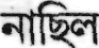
নাছিল
